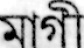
মাগী
